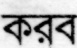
করব
